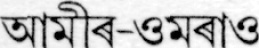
আমীৰ-ওমৰাও
